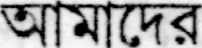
আমাদের
